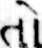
તો
